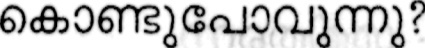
കൊണ്ടുപോവുന്നു?
